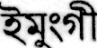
ইমুংগী
